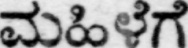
ಮಹಿಳೆಗೆ
